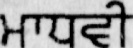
ਮਾਧਵੀ
